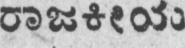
ರಾಜಕೀಯ
